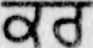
ਕਰ
